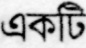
একটি
